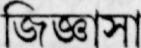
জিজ্ঞাসা
